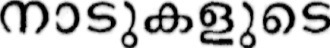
നാടുകളുടെ
